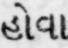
હોવા
